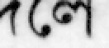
দলে
